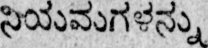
ನಿಯಮಗಳನ್ನು
